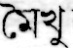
মৈখু
